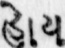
હોય
